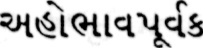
અહોભાવપૂર્વક
